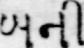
બની
